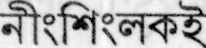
নীংশিংলকই
